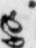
હું
